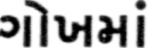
ગોખમાં
